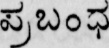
ಪ್ರಬಂಧ
